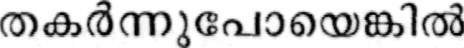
തകര്‍ന്നുപോയെങ്കില്‍
